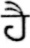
ਹੈ
